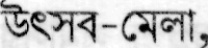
উৎসব-মেলা,
